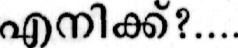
എനിക്ക്?....
